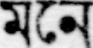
মনে
